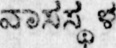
ವಾಸಸ್ಥಳ
